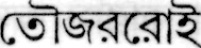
তৌজররোই
